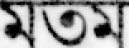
মতম
